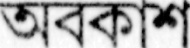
অবকাশ
